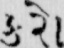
કરો
